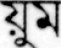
য়ুম
